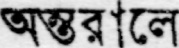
অন্তরালে
